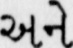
અને
